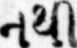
નથી
